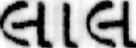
લાલ
